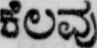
ಕೆಲವು
